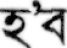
হ'ব
